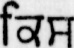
ਕਿਸ
